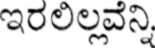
ಇರಲಿಲ್ಲವೆನ್ನಿ.
